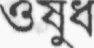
ওষুধ
